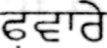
ਫ਼ਵਾਰੇ
